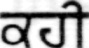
ਕਹੀ
